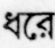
ধরে
